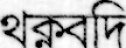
থক্নবদি
